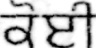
ਕੋਈ
